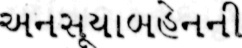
અનસૂયાબહેનની
